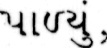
પાળ્યું,
